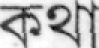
কথা
